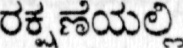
ರಕ್ಷಣೆಯಲ್ಲಿ
